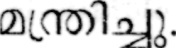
മന്ത്രിച്ചു.
